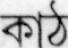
কাঠ
